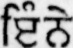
ਇੰਨੇ
